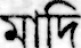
মাদি
